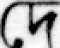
দে
